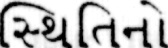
સ્થિતિનો
